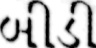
બીડી
